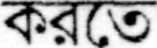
করতে
